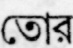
তোর
